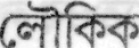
লৌকিক
